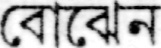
বোঝেন
